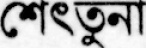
শেৎতুনা
